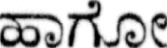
ಹಾಗೋ
